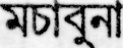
মচাবুনা
